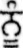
ਨੂੰ
